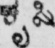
ಕೃಷಿ
